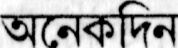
অনেকদিন
